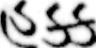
હક્ક
